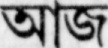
আজ
